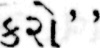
કરો"
